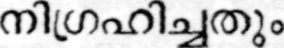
നിഗ്രഹിച്ചതും
